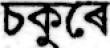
চকুৰে
